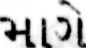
માગે
